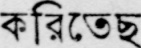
করিতেছ
